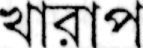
খারাপ
